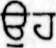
ਉਹ
